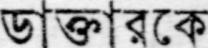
ডাক্তারকে
